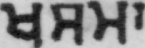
ਖਸਮਾ
